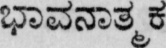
ಭಾವನಾತ್ಮಕ
